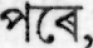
পৰে,
